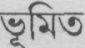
ভূমিত
